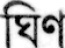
ঘিণ
